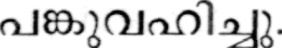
പങ്കുവഹിച്ചു.
